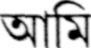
আমি
